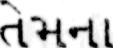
તેમના
